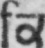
ਕਿ
